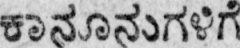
ಕಾನೂನುಗಳಿಗೆ
